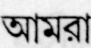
আমরা
